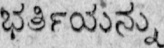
ಭರ್ತಿಯನ್ನು
